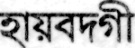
হায়বদগী
